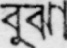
বুঝা
